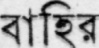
বাহির
